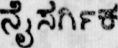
ನೈಸರ್ಗಿಕ
